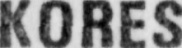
KORES
